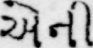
એની
